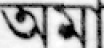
অমা
